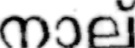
നാല്
